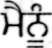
ਮੈਨੂੰ
